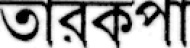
তারকপা
